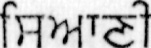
ਸਿਆਣੀ
